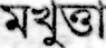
মখুত্তা
